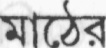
মাঠের
